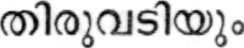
തിരുവടിയും
